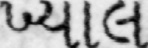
ખ્યાલ
